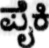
ಪೈಕಿ
